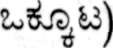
ಒಕ್ಕೂಟ)
